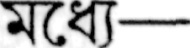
মধ্যে–
